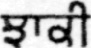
ਝਾਕੀ
